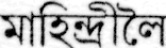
মাহিন্দ্রীলৈ
